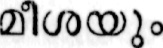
മീശയും
